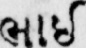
ભાઈ
